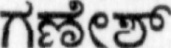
ಗಣೇಶ್
